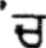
'ਚ
